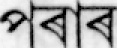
পৰাৰ
